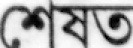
শেষত
